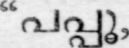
"പപ്പൂ,
